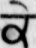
ਕੇ
